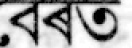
বেৰত
